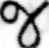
જ
